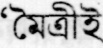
‘মৈত্রীই
